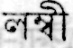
লম্বী
